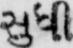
સુધી
